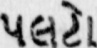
પલટો
